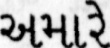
અમારે
